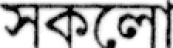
সকলো
